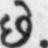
છે.
